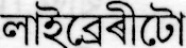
লাইব্রেৰীটো
